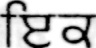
ਇਕ
